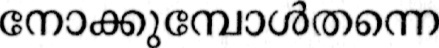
നോക്കുമ്പോള്‍തന്നെ
